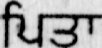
ਪਿਤਾ
